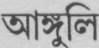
আঙ্গুলি
